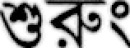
শুরুং
